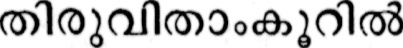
തിരുവിതാംകൂറില്‍
